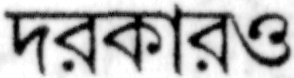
দরকারও
